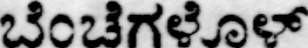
ಬೆಂಚೆಗಳೊಳ್
